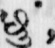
છું.
